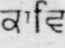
ਕਾਵਿ
